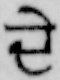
ਦੇ
